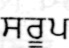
ਸਰੂਪ
